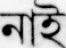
নাই
